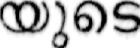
യുടെ
